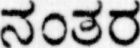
ನಂತರ
